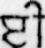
ਈ
